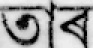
তাৰ
